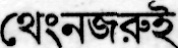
থেংনজরুই
